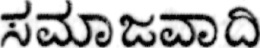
ಸಮಾಜವಾದಿ
